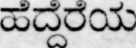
ಹೆದ್ದೆರೆಯ
